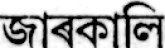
জাৰকালি
